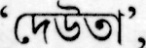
'দেউতা',
